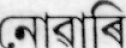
নোৱাৰি
